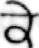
ਕੇ
